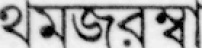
থমজরম্বা
